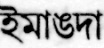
ইমাঙদা
